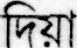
দিয়া
